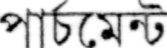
পার্চমেন্ট
